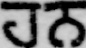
ਹਨ
